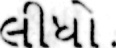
લીધો.
